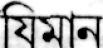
যিমান
